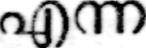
എന്ന
